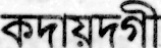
কদাইদগী
